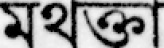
মথক্তা
